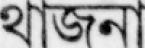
থাজনা
